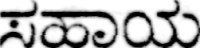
ಸಹಾಯ
